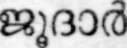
ജൂദാര്‍
